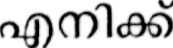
എനിക്ക്
